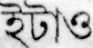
ইটাও
